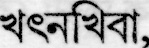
খৎনখিবা,
